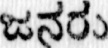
ಜನರು
